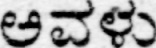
ಅವಳು
